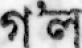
গ'ল
